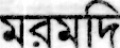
মরমদি
